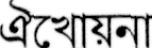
ঐখোয়না
